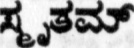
ಸ್ಮ್ರತಮ್
